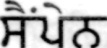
ਸੈਂਪੇਨ
